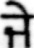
ਜੇ
